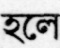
হলে
